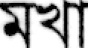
মখা
